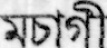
মচাগী
